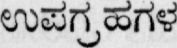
ಉಪಗ್ರಹಗಳ
